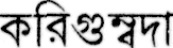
করিগুম্বদা
